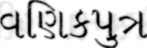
વણિકપુત્ર
